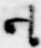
ન
